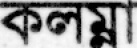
কলম্না
